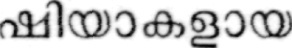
ഷിയാകളായ
